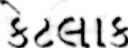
કેટલાક
